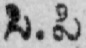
ಸಿ.ಪಿ
